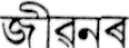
জীৱনৰ
